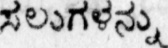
ಸಲುಗಳನ್ನು
